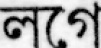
লগে
